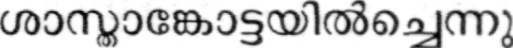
ശാസ്താങ്കോട്ടയില്‍ച്ചെന്നു
